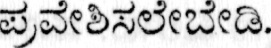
ಪ್ರವೇಶಿಸಲೇಬೇಡಿ.
